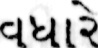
વધારે
